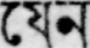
যেন
